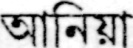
আনিয়া
